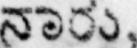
ನಾರು,
